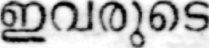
ഇവരുടെ
